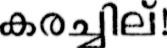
കരച്ചില്!
